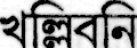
খল্লিবনি
